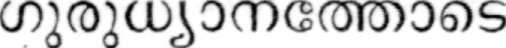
ഗുരുധ്യാനത്തോടെ
